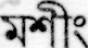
মশীং
